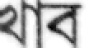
খাব
